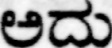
ಅದು
